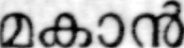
മകാന്‍
